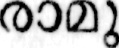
രാമു
